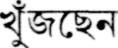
খুঁজছেন
